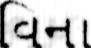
વિના
